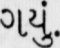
ગયું.
